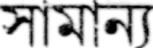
সামান্য
